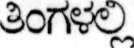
ತಿಂಗಳಲ್ಲಿ
